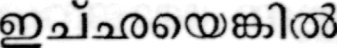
ഇച്ഛയെങ്കില്‍
